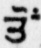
ਤੋਂ
